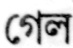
গেল
